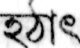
হঠাৎ
